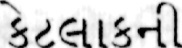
કેટલીકની
